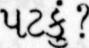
પટકું?
